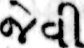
જેવી
